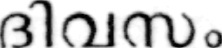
ദിവസം
